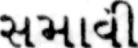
સમાવી
